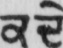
ਕਦੇ
